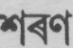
শৰণ
